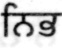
ਨਿਭ
